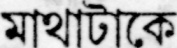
মাথাটাকে
